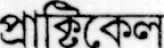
প্রাক্টিকেল
